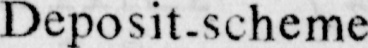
Deposit-scheme
